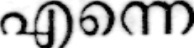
എന്നെ
